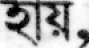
হায়,
